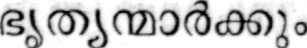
ഭൃത്യന്മാര്‍ക്കും
